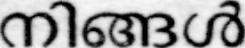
നിങ്ങള്‍
